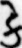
કે
